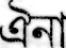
ঐনা
